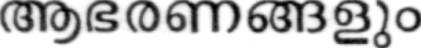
ആഭരണങ്ങളും
